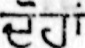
ਦੋਹਾਂ
